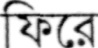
ফিরে
